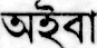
অইবা
